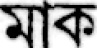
মাক
